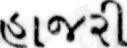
હાજરી
